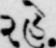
રહે.
